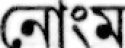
নোংম
